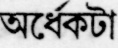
অর্ধেকটা
